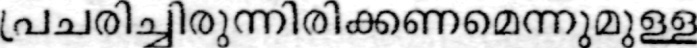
പ്രചരിച്ചിരുന്നിരിക്കണമെന്നുമുള്ള
